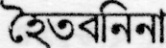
হৈতবনিনা
